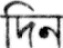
দিন
